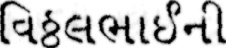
વિઠ્ઠલભાઈની
